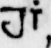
ਹਾਂ,
